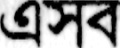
এসব
